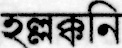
হল্লক্কনি
